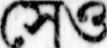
সেও
